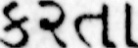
કરતા
